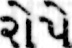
રોપે
